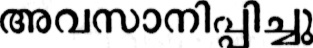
അവസാനിപ്പിച്ചു
